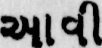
આવી
